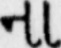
ના
